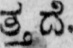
ತ್ತದೆ.
